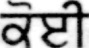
ਕੋਈ
